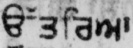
ਉੱਤਰਿਆ
